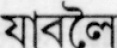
যাবলৈ
